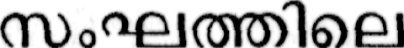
സംഘത്തിലെ
